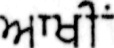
ਆਖੀਂ
